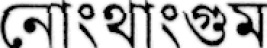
নোংথাঙগুম
